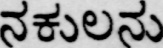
ನಕುಲನು
